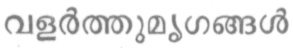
വളര്‍ത്തുമൃഗങ്ങള്‍
